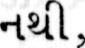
નથી,
